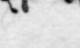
રહેશે
